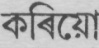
কৰিয়ো
